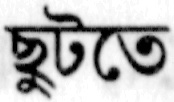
ছুটতে
